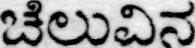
ಚೆಲುವಿನ
